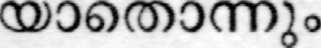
യാതൊന്നും
